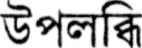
উপলব্ধি
